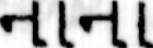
નાના
